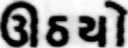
ઊઠ્યો
